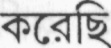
করেছি
